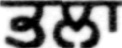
ਭਲਾ
